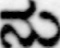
ನು
